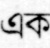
এক
